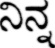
ನಿನ್ನ
